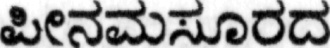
ಪೀನಮಸೂರದ
